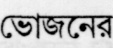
ভোজনের
